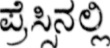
ಪ್ರೆಸ್ಸಿನಲ್ಲಿ
